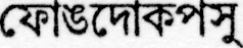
ফোঙদোকপসু
